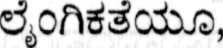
ಲೈಂಗಿಕತೆಯೂ,
